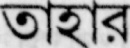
তাহার
